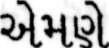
એમણે
